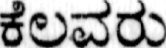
ಕೆಲವರು
